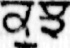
ਕੁਝ
